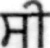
ਸੀ
